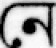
নে
